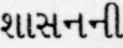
શાસનની
